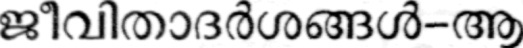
ജീവിതാദര്‍ശങ്ങള്‍-ആ
